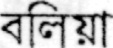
বলিয়া
